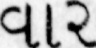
વાર
